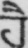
ਹੈ
